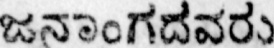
ಜನಾಂಗದವರು
